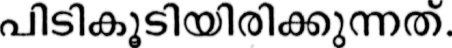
പിടികൂടിയിരിക്കുന്നത്.
